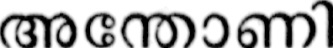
അന്തോണി
